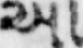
આ
